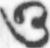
ও
